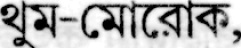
থুম-মোরোক,
